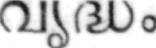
വൃദ്ധം
